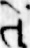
તેં
